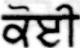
ਕੋਈ
